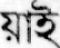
য়াই
